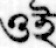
ওই
